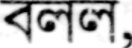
বলল,
